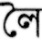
লৈ
